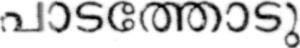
പാടത്തോടു
